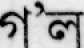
গ'ল
